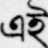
এই
